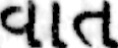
વાત
